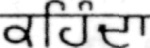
ਕਹਿੰਦਾ
